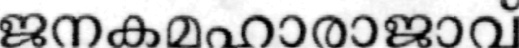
ജനകമഹാരാജാവ്
